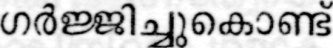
ഗര്‍ജ്ജിച്ചുകൊണ്ട്
